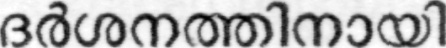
ദര്‍ശനത്തിനായി
